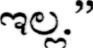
ಇಲ್ಲ."
